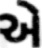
એ
